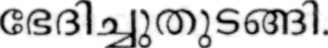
ഭേദിച്ചുതുടങ്ങി.
